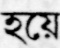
হয়ে
